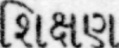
શિક્ષણ
